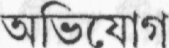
অভিযোগ
